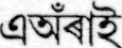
এঅঁৰাই
